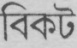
বিকট
